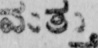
ಮತ್ತು
